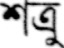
শত্রু
